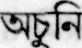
অচুনি
